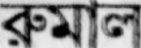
রুমাল
